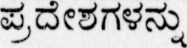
ಪ್ರದೇಶಗಳನ್ನು
